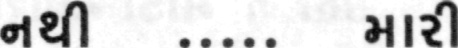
નથી......મારી
